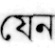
যেন
